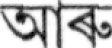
আৰু
